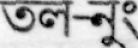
তল-নুং
